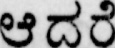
ಆದರೆ
